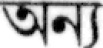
অন্য
